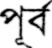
পূর্ব
